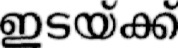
ഇടയ്ക്ക്
